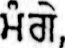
ਮੰਗੇ,
